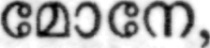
മോനേ,
